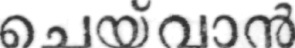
ചെയ്വാന്‍
